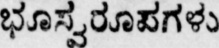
ಭೂಸ್ವರೂಪಗಳು
